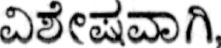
ವಿಶೇಷವಾಗಿ,
